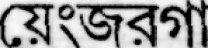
য়েংজরগা
